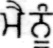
ਮੈਨੂੰ
